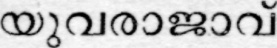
യുവരാജാവ്
